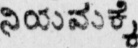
ನಿಯಮಕ್ಕೆ
